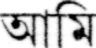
আমি
